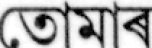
তোমাৰ
